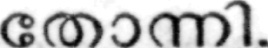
തോന്നി.
